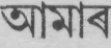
আমাৰ
